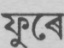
ফুৰে
